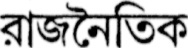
রাজনৈতিক
